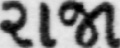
રાજા
